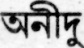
অনীদু
